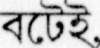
বটেই,
